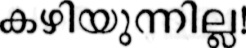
കഴിയുന്നില്ല!
